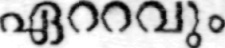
ഏററവും
